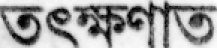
তৎক্ষণাত
